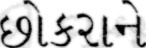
છોકરાને
